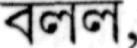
বলল,
